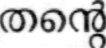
തന്റെ
